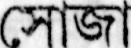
সোজা
